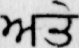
ਅਤੇ
